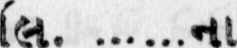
લિ.........ના
